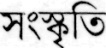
সংস্কৃতি
